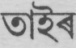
তাইৰ
